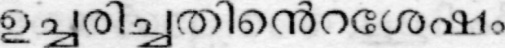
ഉച്ചരിച്ചതിന്റെശേഷം
